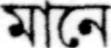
মানে
